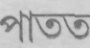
পাতত
